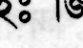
আইঃ
